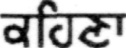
ਕਹਿਣਾ
